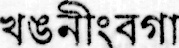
খঙনীংবগা
